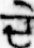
ਦੇ
